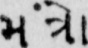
મંત્રો
